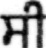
ਸੀ
